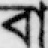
বা
